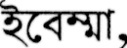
ইবেম্মা,
